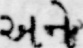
અને
